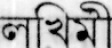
লখিমী
